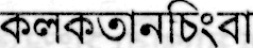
কলকতানচিংবা
